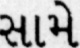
સામે
